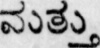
ಮತ್ತು
